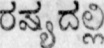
ರಷ್ಯದಲ್ಲಿ
